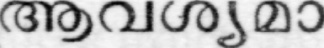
ആവശ്യമാ
